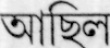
আছিল
